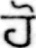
ਹੋ
